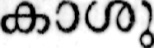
കാശു
